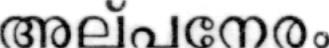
അല്പനേരം
